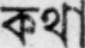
কথা
